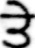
ਤੇ
